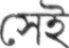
সেই
